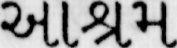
આશ્રમ
